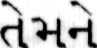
તેમને
